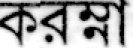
করম্না
